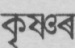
কৃষ্ণৰ
